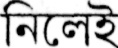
নিলেই
